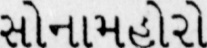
સોનામહોરો
